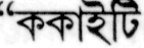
"ককাইটি
